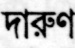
দারুণ
